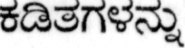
ಕಡಿತಗಳನ್ನು
